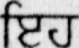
ਇਹ
